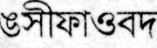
ঙসীফাওবদা
